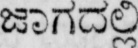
ಜಾಗದಲ್ಲಿ
